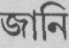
জানি
